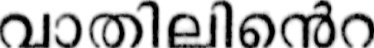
വാതിലിന്റെ
